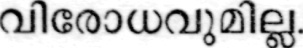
വിരോധവുമില്ല.
